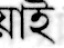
য়াই
